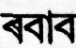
ৰবাব
